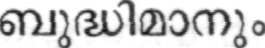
ബുദ്ധിമാനും
